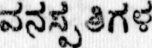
ವನಸ್ಪತಿಗಳ
